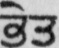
ਭੇਤ
